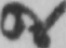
જ
